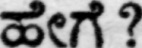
ಹೇಗೆ?
